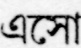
এসো
